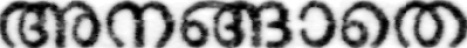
അനങ്ങാതെ
